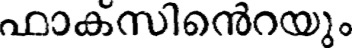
ഫാക്സിന്റെയും
